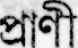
প্রাণী
